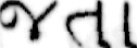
જતા
